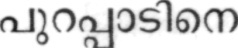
പുറപ്പാടിനെ
